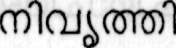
നിവൃത്തി
